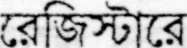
রেজিস্টারে
